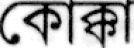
কোক্কা
